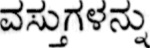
ವಸ್ತುಗಳನ್ನು
